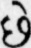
છે
